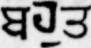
ਬਹੁਤ
